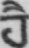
ਹੈ
